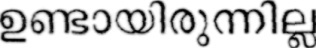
ഉണ്ടായിരുന്നില്ല
